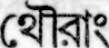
থৌরাং
